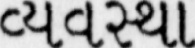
વ્યવસ્થા
